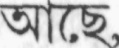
আছে,
